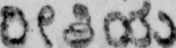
ರೀತಿಯ
